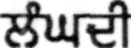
ਲੰਘਦੀ
